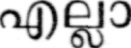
എല്ലാ
